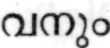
വനും
